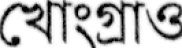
খোংগ্রাও
